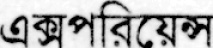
এক্সপরিয়েন্স
